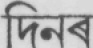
দিনৰ
